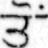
ਤੋਂ
